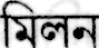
মিলন
